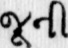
જૂની
